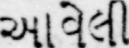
આવેલી
